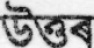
উত্তৰ
